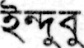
ইন্দুবু
